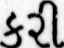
કરી
